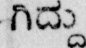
ಗಿದ್ದು
